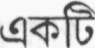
একটি
